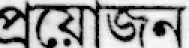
প্রয়োজন
